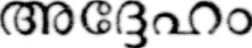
അദ്ദേഹം
